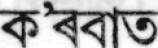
ক'ৰবাত
